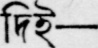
দিই—
